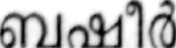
ബഷീര്‍
